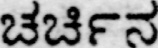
ಚರ್ಚಿನ
